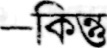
-কিন্তু
